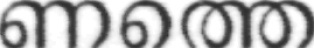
ണത്തെ
